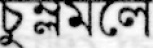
চুম্লমলে
